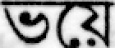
ভয়ে
